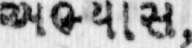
અભ્યાસ,
